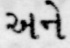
અને
